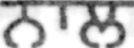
ਨਾਲ
